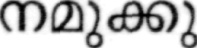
നമുക്കു
